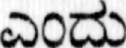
ಎಂದು
